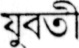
যুবতী
